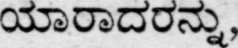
ಯಾರಾದರನ್ನು,
